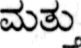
ಮತ್ತು
